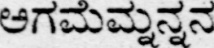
ಅಗಮೆಮ್ನನ್ನನ
